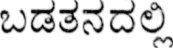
ಬಡತನದಲ್ಲಿ
